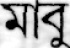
মাবু
